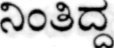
ನಿಂತಿದ್ದ
